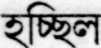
হচ্ছিল
